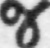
જ
